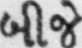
બીજે
